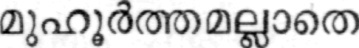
മുഹൂര്‍ത്തമല്ലാതെ
